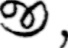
જી,
